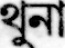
থুনা
